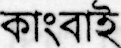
কাংবাই
